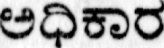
ಅಧಿಕಾರ
